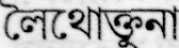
লৈথোক্তুনা
